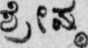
ಶ್ರೇಷ್ಠ
